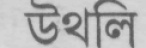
উথলি
